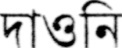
দাওনি
